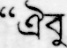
“ঐবু
